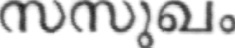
സസുഖം
